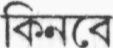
কিনবে
